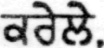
ਕਰੇਲੇ,
